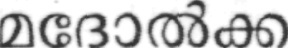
മദോല്‍ക്ക
